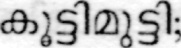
കൂട്ടിമുട്ടി;
